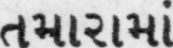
તમારામાં
